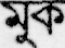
মুক
